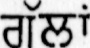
ਗੱਲਾਂ
